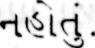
નહોતું.
